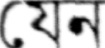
যেন
